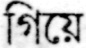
গিয়ে
